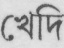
খেদি
